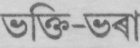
ভক্তি-ভৰা
